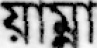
য়াম্না
